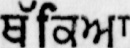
ਥੱਕਿਆ
